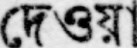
দেওয়া
